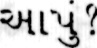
આપું?
